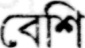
বেশি
